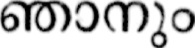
ഞാനും
